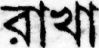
রাখা
